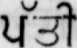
ਪੱਤੀ
